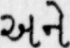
અને
